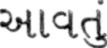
આવતું
